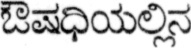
ಔಷಧಿಯಲ್ಲಿನ
